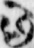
છે
